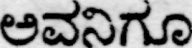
ಅವನಿಗೂ
